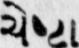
ચેષ્ટા
